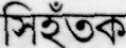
সিহঁতক
